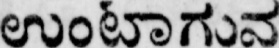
ಉಂಟಾಗುವ
